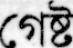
গেষ্ট
